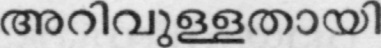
അറിവുള്ളതായി
